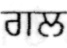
ਗਲ
